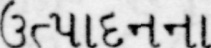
ઉત્પાદનના
